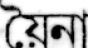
য়ৈনা
